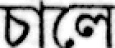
চালে
